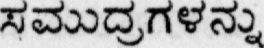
ಸಮುದ್ರಗಳನ್ನು
